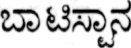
ಬಾಟಿಸ್ಟಾನ
